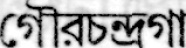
গৌরচন্দ্রগা
